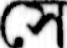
সে
